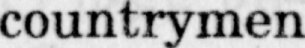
countrymen
